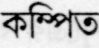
কম্পিত
